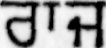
ਰਾਜ
